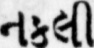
નકલી
